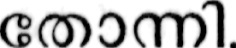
തോന്നി.
